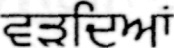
ਵੜਦਿਆਂ
